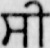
ਸੀ
